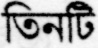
তিনটি
